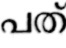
പത്
